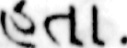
હતા.
